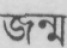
জন্ম
